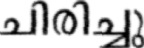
ചിരിച്ചു
